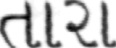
તારા
